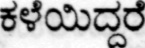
ಕಳೆಯಿದ್ದರೆ
